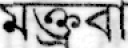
মক্ত্রবা
